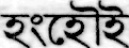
হংহৌই
